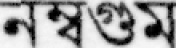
নম্বগুম
